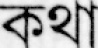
কথা
